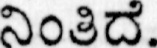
ನಿಂತಿದೆ.
